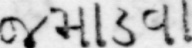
જમાડવા
